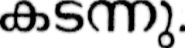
കടന്നു.
